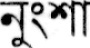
নুংশা
